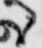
જે
